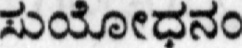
ಸುಯೋಧನಂ
